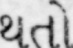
થતો
